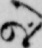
જે
